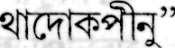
থাদোকপীনু”
